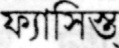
ফ্যাসিস্ত
